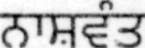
ਨਾਸ਼ਵੰਤ
